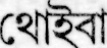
থোইবা
